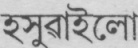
হসুৱাইলো
